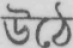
উঠে
